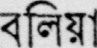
বলিয়া
